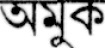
অমুক
